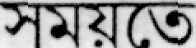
সময়তে
